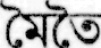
মৈতৈ
